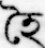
হৈ
